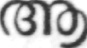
ആ
